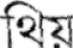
থিয়
